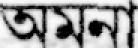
অমনা
